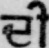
ਦੀ
